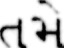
તમે
